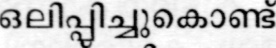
ഒലിപ്പിച്ചുകൊണ്ട്
